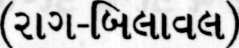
(રાગ-બિલાવલ)
